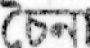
চৈনা
